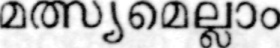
മത്സ്യമെല്ലാം
